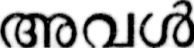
അവള്‍
